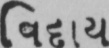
વિદાય
